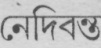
নেদিবন্ত
